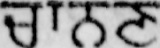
ਚਾਨਣ
